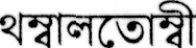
থম্বালতোম্বী
